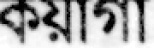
কয়াগা
